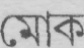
মোক
